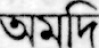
অমদি
